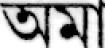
অমা
